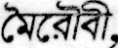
মৈরৌবী,
